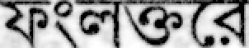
ফংলক্তরে
